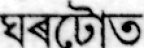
ঘৰটোত
